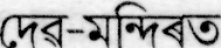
দেৱ-মন্দিৰত
